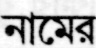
নামের
